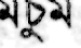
মচুম
